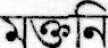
মক্তনি
